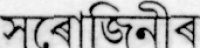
সৰোজিনীৰ
